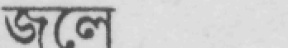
জলে
